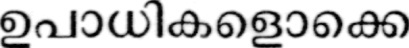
ഉപാധികളൊക്കെ
